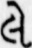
લે
